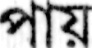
পায়
